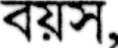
বয়স,
